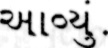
આવ્યું.
